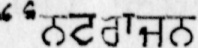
''ਨਟਰਾਜਨ
